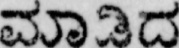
ಮಾಡಿದ
